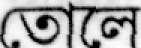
তোলে
